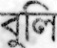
বুলি
